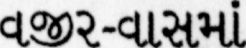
વજીર-વાસમાં
